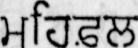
ਮਹਿਫ਼ਲ
